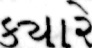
ક્યારે
